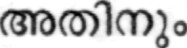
അതിനും
